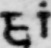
ਥਾਂ
